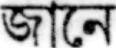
জানে
